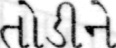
તોડીને
